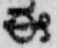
ಈ
